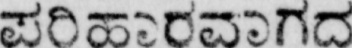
ಪರಿಹಾರವಾಗದ
